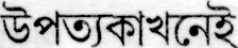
উপত্যকাখনেই
